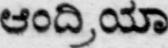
ಆಂದ್ರಿಯಾ
